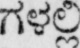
ಗಳಲ್ಲಿ
